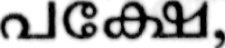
പക്ഷേ,
